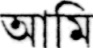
আমি
